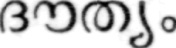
ദൌത്യം
